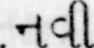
નવી
